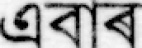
এবাৰ
